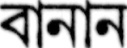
বানান
